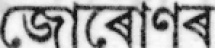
জোৰোণৰ
